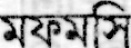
মফমসি
